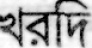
খরদি
